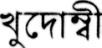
খুদোম্বী
